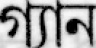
গ্যান
